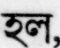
হল,
